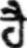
ਹੈ
